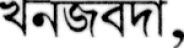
খনজবদা,
